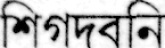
শিগদবনি
